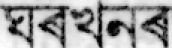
ঘৰখনৰ
